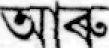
আৰু
